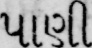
પાણી
